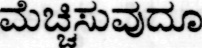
ಮೆಚ್ಚಿಸುವುದೂ
